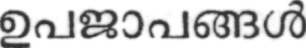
ഉപജാപങ്ങള്‍
